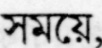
সময়ে,
